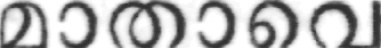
മാതാവെ
